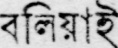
বলিয়াই
